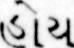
હોય
